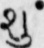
શું
